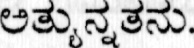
ಅತ್ಯುನ್ನತನು.
